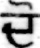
ਦੋ
